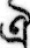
ঐ
